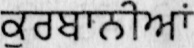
ਕੁਰਬਾਨੀਆਂ
